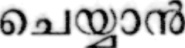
ചെയ്യാന്‍
